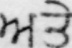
ਅਤੇ
